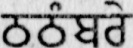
ਠਠੰਬਰੇ
